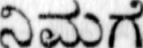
ನಿಮಗೆ
